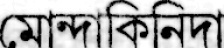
মোন্দাকিনিদা
